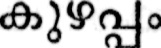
കുഴപ്പം
